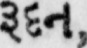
રૂદન,
